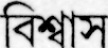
বিশ্বাস
